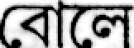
বোলে
